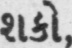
શકો,
